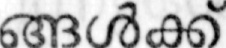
ങ്ങള്‍ക്ക്
